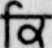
ਕਿ
